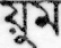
য়ুম
